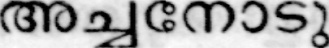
അച്ചനോടു
